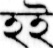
হই
